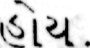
હોય.
